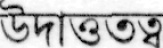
উদাত্ততত্ব
